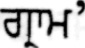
ਗ੍ਰਾਮ'
